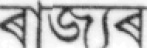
ৰাজ্যৰ
